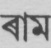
ৰাম
